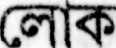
লোক
